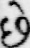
છે
